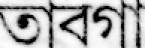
তাবগা
